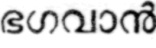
ഭഗവാന്‍
